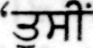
'ਤੁਸੀਂ
